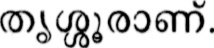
തൃശ്ശൂരാണ്.
